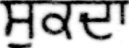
ਸੁਕਦਾ
